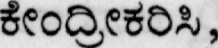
ಕೇಂದ್ರೀಕರಿಸಿ,
